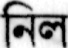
নিল
